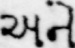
અને
